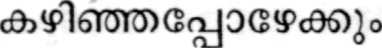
കഴിഞ്ഞപ്പോഴേക്കും
